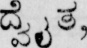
ದ್ವೈತ,
